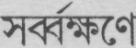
সৰ্ব্বক্ষণে
